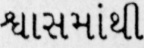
શ્વાસમાંથી
